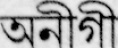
অনীগী
